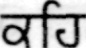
ਕਹਿ
